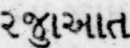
રજુ।આત
